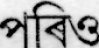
পৰিও
